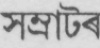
সম্রাটৰ
